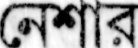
নেশার
